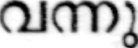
വന്നു
